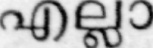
എല്ലാ
